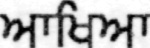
ਆਖਿਆ
